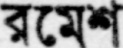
রমেশ
